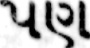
પણ
